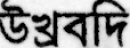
উখ্রবদি
